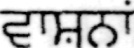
ਵਾਸ਼ਨਾਂ
